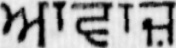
ਆਵਾਜ਼
